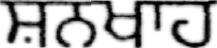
ਸ਼ਨਖਾਹ
